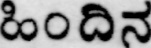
ಹಿಂದಿನ
